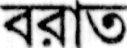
বরাত
